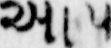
આપ
